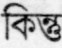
কিন্তু
